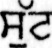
ਸੁੱਟ
